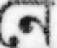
নে
